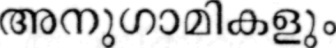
അനുഗാമികളും
